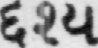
દ્દશ્ય
